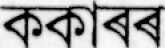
ককাৰৰ
